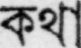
কথা
